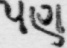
પણ
